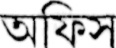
অফিস
